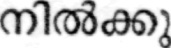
നില്‍ക്കു
